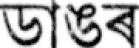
ডাঙৰ
